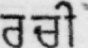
ਰਚੀ
